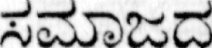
ಸಮಾಜದ
